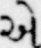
એ
